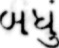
બધું
